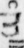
ਤੂੰ
